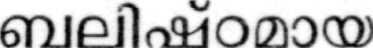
ബലിഷ്ഠമായ
